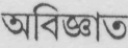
অবিজ্ঞাত
